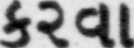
કરવા
